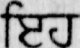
ਇਹ
